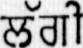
ਲੱਗੀ
